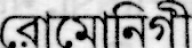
রোমোনিগী
